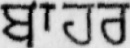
ਬਾਹਰ
